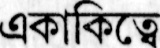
একাকিত্বে
